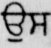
ਉਸ
